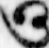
ও
